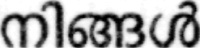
നിങ്ങള്‍
